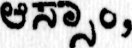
ಆಸ್ಸಾಂ,
